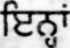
ਇਨ੍ਹਾਂ
